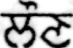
ਲੌਣ
